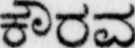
ಕೌರವ
